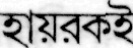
হায়রকই
